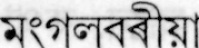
মংগলবৰীয়া
